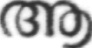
ആ
